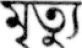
মৃত্যু
